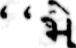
"મે
